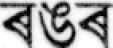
ৰঙৰ
